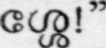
ശ്ശേ!"
